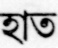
হাত
